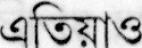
এতিয়াও
